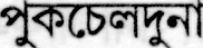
পুকচেলদুনা
